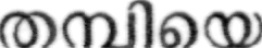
തമ്പിയെ
